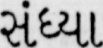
સંધ્યા
